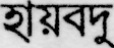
হায়বদু
